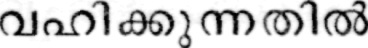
വഹിക്കുന്നതില്‍
